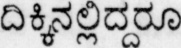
ದಿಕ್ಕಿನಲ್ಲಿದ್ದರೂ
